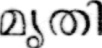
മൃതി
